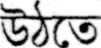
উঠতে
